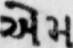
એમ
